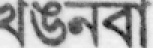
খঙনবা
